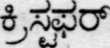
ಕ್ರಿಸ್ಟಫರ್
